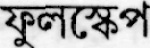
ফুলস্কেপ
